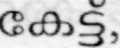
കേട്ട്,
